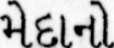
મેદાનો
